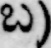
ಬ)
